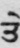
ਤੇ
